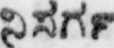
ನಿಸರ್ಗ
